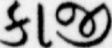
કાજી
